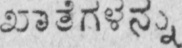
ಖಾತೆಗಳನ್ನು
